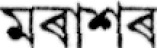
মৰাশৰ
